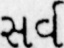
સર્વ
